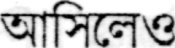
আসিলেও
